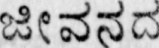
ಜೀವನದ
